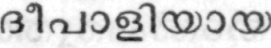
ദീപാളിയായ
